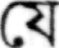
যে
